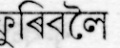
ফুৰিবলৈ
